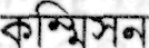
কম্মিসন
